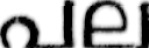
പല
